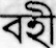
বহী
